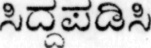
ಸಿದ್ದಪಡಿಸಿ
